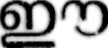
ഈ
